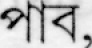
পাব,
